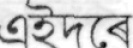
এইদৰে
